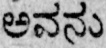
ಅವನು
